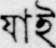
যাই
